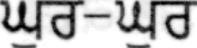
ਘੁਰ-ਘੁਰ
